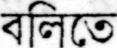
বলিতে
